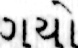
ગયો
